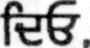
ਦਿਓ,
